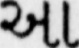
આ
